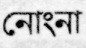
নোংনা
